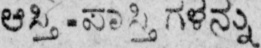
ಆಸ್ತಿ-ಪಾಸ್ತಿಗಳನ್ನು
